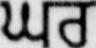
ਘਰ
